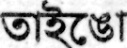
তাইঙো
